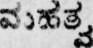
ಮಹತ್ವ
